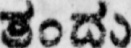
ತಂದು
